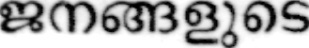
ജനങ്ങളുടെ
